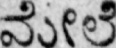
ಮೇಲೆ
